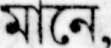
মানে,
